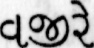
વજીરે
